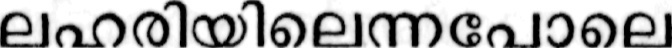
ലഹരിയിലെന്നപോലെ
